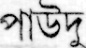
পাউদু
